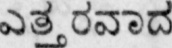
ಎತ್ತರವಾದ
